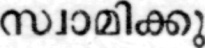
സ്വാമിക്കു
